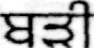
ਬੜੀ
